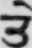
ਤੇ
